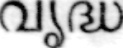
വൃദ്ധ
